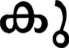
കു
